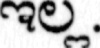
ಇಲ್ಲ.
